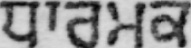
ਧਾਰਮਕ
